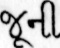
જૂની
